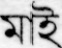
মাই
